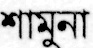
শামুনা
